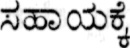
ಸಹಾಯಕ್ಕೆ
